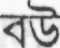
বউ
